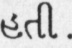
હતી.
